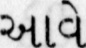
આવે
